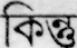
কিন্তু
